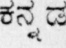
ಕನ್ನಡ
